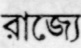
রাজ্যে
